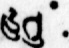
હતું.
